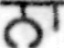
ਨਾ
